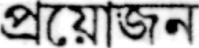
প্রয়োজন
